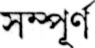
সম্পূর্ণ
